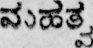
ಮಹತ್ವ
